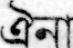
ঐনা
